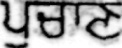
ਪੁਚਾਣ
